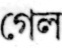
গেল
